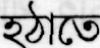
হঠাতে
